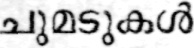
ചുമടുകള്‍
